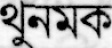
থুনমক
